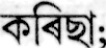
কৰিছা;
